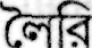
লৈরি
